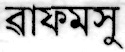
ৱাফমসু
